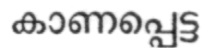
കാണപ്പെട്ട
